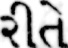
રીતે
